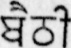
ਬੈਠੀ
